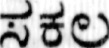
ಸಕಲ
